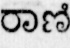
ರಾಣಿ
